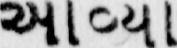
આવ્યા
